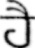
ਹੈ
